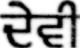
ਦੇਵੀ
